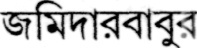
জমিদারবাবুর
